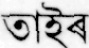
তাইৰ
